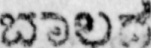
ಬಾಲದ
